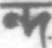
ন্দ
